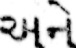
અને
